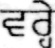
ਵਰ੍ਹੇ
